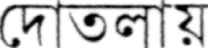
দোতলায়
